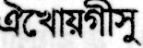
ঐখোয়গীসু
